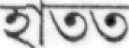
হাতত
